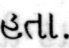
હતા.
